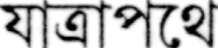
যাত্রাপথে
